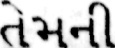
તેમની
